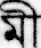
মী
